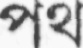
পথ
